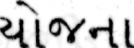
યોજના
